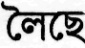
লৈছে
